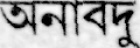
অনাবদু
